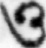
ও
